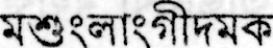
মশুংলাংগীদমক
